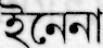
ইনেনা
